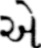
એ
